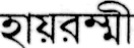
হায়রম্মী
